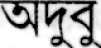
অদুবু
